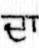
ਦਾ
